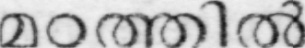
മഠത്തില്‍
